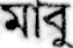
মাবু
